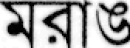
মরাঙ
